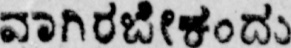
ವಾಗಿರಬೇಕಂದು
